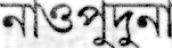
নাওপুদুনা
